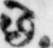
છે.
